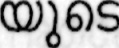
യുടെ
